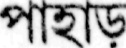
পাহাড়
